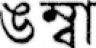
ঙম্বা
